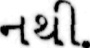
નથી
